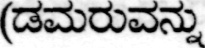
(ಡಮರುವನ್ನು
